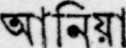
আনিয়া
